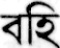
বহি
